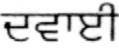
ਦਵਾਈ
